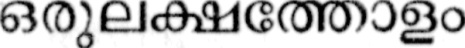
ഒരുലക്ഷത്തോളം
